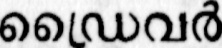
ഡ്രൈവര്‍
